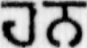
ਹਨ
